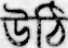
উঠি
